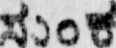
ಸುಂಕ
